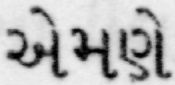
એમણે
